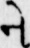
ને
